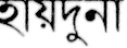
হায়দুনা
